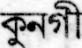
কুনগী
